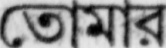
তোমার
